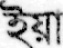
ইয়া
